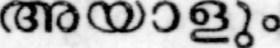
അയാളും
